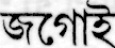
জগোই
